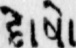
દોષો
